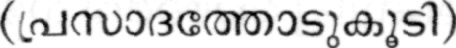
(പ്രസാദത്തോടുകൂടി)
